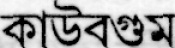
কাউবগুম
